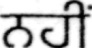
ਨਹੀਂ
